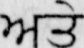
ਅਤੇ
